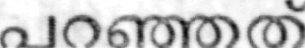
പറഞ്ഞത്
